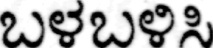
ಬಳಬಳಿಸಿ
